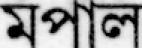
মপাল
